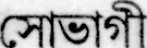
সোভাগী
